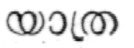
യാത്ര
